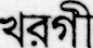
খরগী
